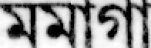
মমাগা
